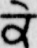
ਕੇ
